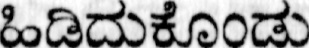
ಹಿಡಿದುಕೊಂಡು
